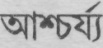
আশ্চৰ্য্য
